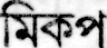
মিকপ
